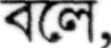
বলে,
